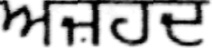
ਅਜ਼ਹਦ
